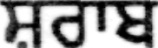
ਸ਼ਰਾਬ
